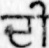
ਦੀ
